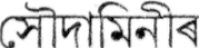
সৌদামিনীৰ
